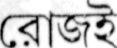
রোজই
